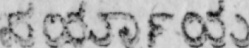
ಪರ್ಯಾಯ
